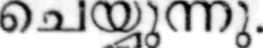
ചെയ്യുന്നു.
